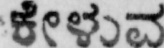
ಕೇಳುವ
